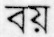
বয়
